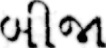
બીજા
